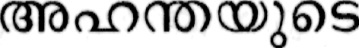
അഹന്തയുടെ
